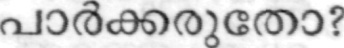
പാര്‍ക്കരുതോ?
